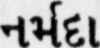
નર્મદા
